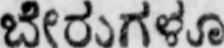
ಬೇರುಗಳೂ
